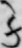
કે
